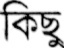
কিছু
